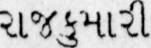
રાજકુમારી
